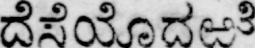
ದೆಸೆಯೊದಱೆ
